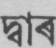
দ্বাৰ
